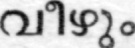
വീഴും
